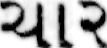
ચાર
